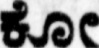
ಕೋ
